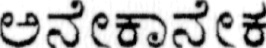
ಅನೇಕಾನೇಕ
